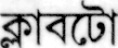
ক্লাবটো
